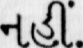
નહીં.
